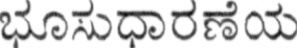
ಭೂಸುಧಾರಣೆಯ
